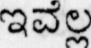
ಇವೆಲ್ಲ
